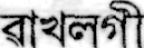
ৱাখলগী
